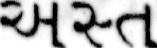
અસ્ત
